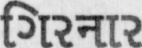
ગિરનાર
